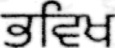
ਭਵਿਖ
